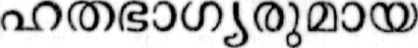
ഹതഭാഗ്യരുമായ
